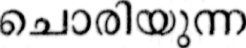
ചൊരിയുന്ന
